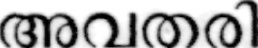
അവതരി
